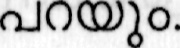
പറയും.
